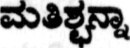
ಮತಿಶ್ಛನ್ನಾ
